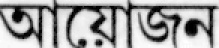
আয়োজন
